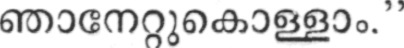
ഞാനേറ്റുകൊള്ളാം."
